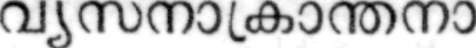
വ്യസനാക്രാന്തനാ
